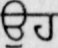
ਉਹ
